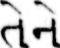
તેને
